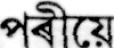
পৰীয়ে
